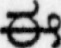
ಈ
